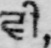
ਵੀ,
